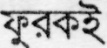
ফুরকই
